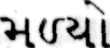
મળ્યો
